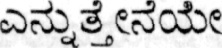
ಎನ್ನುತ್ತೇನೆಯೇ
